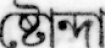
ষ্টোন্দা
